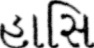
હાસિ
